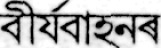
বীর্যবাহনৰ
